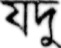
যদু
